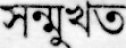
সন্মুখত
